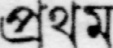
প্রথম
